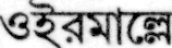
ওইরমাল্লে
